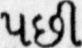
પછી
